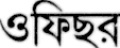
ওফিছর
